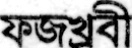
ফজখ্রবী
